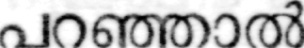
പറഞ്ഞാല്‍
